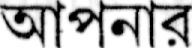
আপনার
